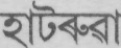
হাটৰুৱা
